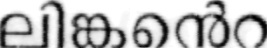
ലിങ്കന്റെ
